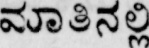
ಮಾತಿನಲ್ಲಿ
